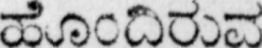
ಹೊಂದಿರುವ
